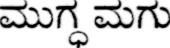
ಮುಗ್ಧಮಗು
